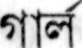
গার্ল
